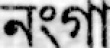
নংগা
